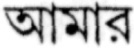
আমার
